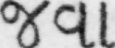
જવા
